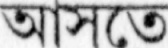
আসতে
